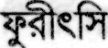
ফুরীৎসি
